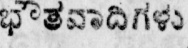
ಭೌತವಾದಿಗಳು
